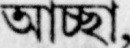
আচ্ছা,
